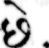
છે.
